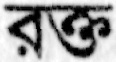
রক্ত
